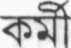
কর্মী
